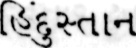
હિંદુસ્તાન
